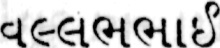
વલ્લભભાઈ
